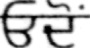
ਓਦੋਂ
